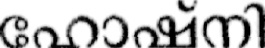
ഹോഷ്നി
